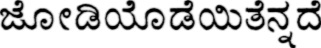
ಜೋಡಿಯೊಡೆಯಿತೆನ್ನದೆ
